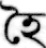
হৈ
